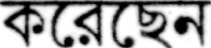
করেছেন
